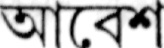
আবেশ
